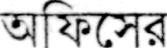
অফিসের
